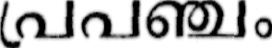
പ്രപഞ്ചം
